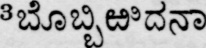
3ಬೊಬ್ಬಿಱಿದನಾ
